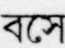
বসে
